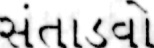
સંતાડવો
